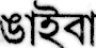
ঙাইবা
